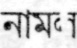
নামল
